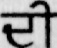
ਦੀ
